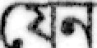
যেন
